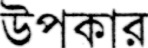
উপকার
